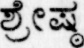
ಶ್ರೇಷ್ಠ
